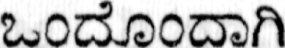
ಒಂದೊಂದಾಗಿ
